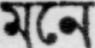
মনে
